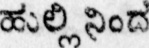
ಹುಲ್ಲಿನಿಂದ
